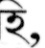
হি,
